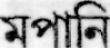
মপানি
